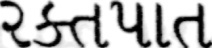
રક્તપાત
